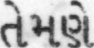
તેમણે
